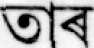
তাৰ
